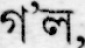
গ'ল,
